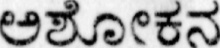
ಅಶೋಕನ
